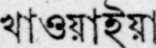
খাওয়াইয়া
